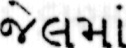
જેલમાં
